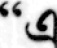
"এ
